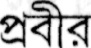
প্রবীর
